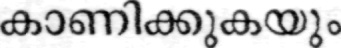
കാണിക്കുകയും
